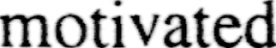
motivated
